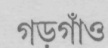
গড়গাঁও
